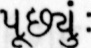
પૂછ્યું:
